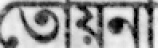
তোয়না
